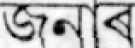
জনাৰ
